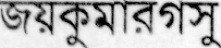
জয়কুমারগসু
